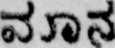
ಮಾನ
